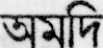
অমদি
